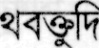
থবক্তুদি
